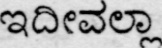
ಇದೀವಲ್ಲಾ
